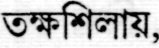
তক্ষশিলায়,
